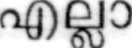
എല്ലാ
